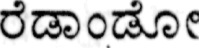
ರೆಡಾಂಡೋ
